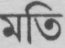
মতি
